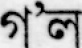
গ'ল
